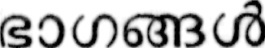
ഭാഗങ്ങള്‍
